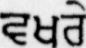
ਵਖਰੇ
